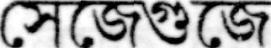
সেজেগুজে
